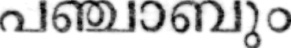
പഞ്ചാബും
